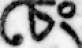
চেং
